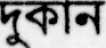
“করিগীনো
